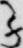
કે
